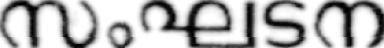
സംഘടന
